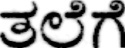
ತಲೆಗೆ
